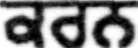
ਕਰਨ
